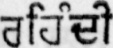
ਰਹਿੰਦੀ
